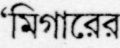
‘মিগারের
